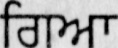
ਗਿਆ
